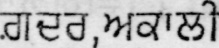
ਗ਼ਦਰ,ਅਕਾਲੀ
